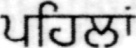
ਪਹਿਲਾਂ
